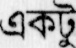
একটু
